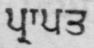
ਪ੍ਰਾਪਤ
